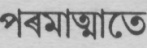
পৰমাত্মাতে
